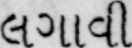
લગાવી
